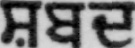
ਸ਼ਬਦ
